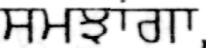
ਸਮਝਾਂਗਾ,
